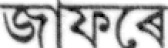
জাফৰে
